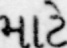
માટે
